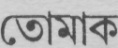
তোমাক
